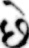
છે
